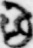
છે
